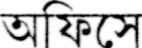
অফিসে
